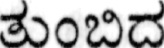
ತುಂಬಿದ
